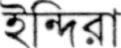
ইন্দিরা
